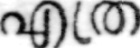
എത്ര
